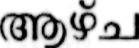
ആഴ്ച
